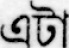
এটা
